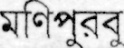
মণিপুরবু
